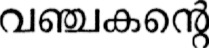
വഞ്ചകന്റെ
